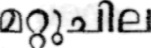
മറ്റുചില
